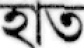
হাত
